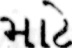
માટે
